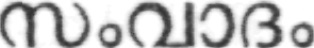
സംവാദം
